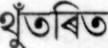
থুঁতৰিত
